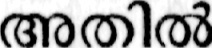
അതില്‍
